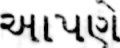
આપણે
